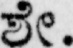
ಶೇ.
